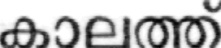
കാലത്ത്
